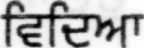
ਵਿਦਿਆ
